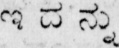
ಇದನ್ನು
